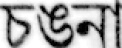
চঙনা
